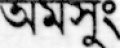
অমসুং
